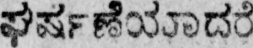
ಘರ್ಷಣೆಯಾದರೆ
